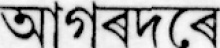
আগৰদৰে
